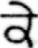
ਕੇ
